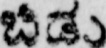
ಬಿಡು
